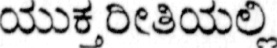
ಯುಕ್ತರೀತಿಯಲ್ಲಿ
